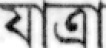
যাত্রা
